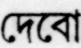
দেবো
